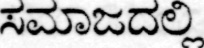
ಸಮಾಜದಲ್ಲಿ
